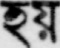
হয়
